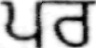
ਪਰ
